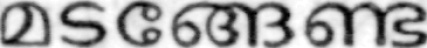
മടങ്ങേണ്ട
